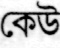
কেউ
